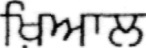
ਖ਼ਿਆਲ
